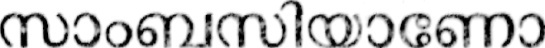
സാംബസിയാണോ
